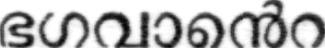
ഭഗവാന്റെ
